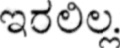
ಇರಲಿಲ್ಲ.
